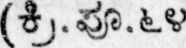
(ಕ್ರಿ.ಪೂ.೬೪
